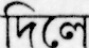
দিলে
